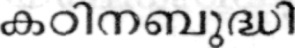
കഠിനബുദ്ധി
